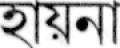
হায়না
